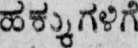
ಹಕ್ಕುಗಳಿಗೆ
